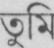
তুমি
